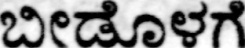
ಬೀಡೊಳಗೆ
